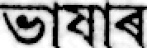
ভাষাৰ
